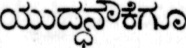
ಯುದ್ಧನೌಕೆಗೂ
